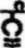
ਨੂੰ
